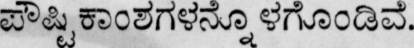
ಪೌಷ್ಟಿಕಾಂಶಗಳನ್ನೊಳಗೊಂಡಿವೆ.
